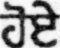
ਹੋਏ
